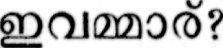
ഇവമ്മാര്?
